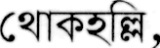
থোকহল্লি,
